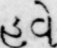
હવે
